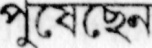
পুষেছেন
